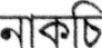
নাকচি
